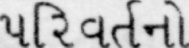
પરિવર્તનો
